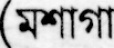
(মশাগা
